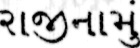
રાજીનામું
